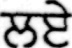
ਲਏ
